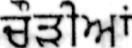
ਚੌੜੀਆਂ
